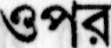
ওপর
